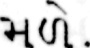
મળે.
